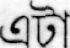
এটা
